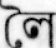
লৈ
